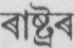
ৰাষ্ট্ৰৰ
